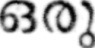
ഒരു
